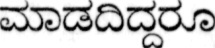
ಮಾಡದಿದ್ದರೂ
